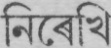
নিৰেখি
